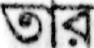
তার
